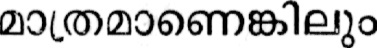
മാത്രമാണെങ്കിലും
